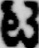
ಟ
